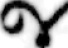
જ
